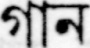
গান
